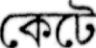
কেটে
